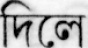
দিলে
